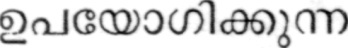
ഉപയോഗിക്കുന്ന
